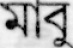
মাবু
